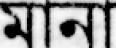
মানা
